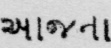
આજના
